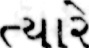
ત્યારે
